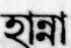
হান্না
